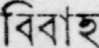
বিবাহ
